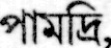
পামদ্রি,
